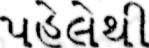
પહેલેથી
